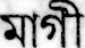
মাগী
